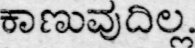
ಕಾಣುವುದಿಲ್ಲ.
